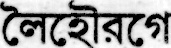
লৈহৌরগে
